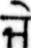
ਜੇ
